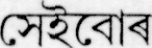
সেইবোৰ
